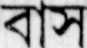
বাস
